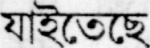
যাইতেছে
